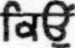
ਕਿਉਂ
